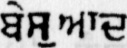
ਬੇਸੁਆਦ
